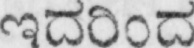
ಇದರಿಂದ
